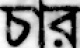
চার
